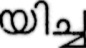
യിച്ച
